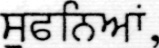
ਸੁਫਨਿਆਂ,
